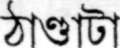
ঠাণ্ডাটা
